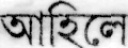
আহিলে
